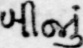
બીજું
